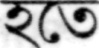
হতে
